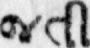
જતી
